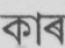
কাৰ
